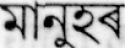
মানুহৰ
